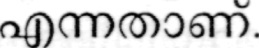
എന്നതാണ്.
